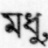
মধু,
